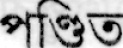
পণ্ডিত
